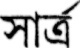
সার্ত্র
